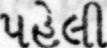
પહેલી
